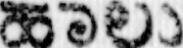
ಹಾಲು
